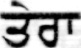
ਤੇਰਾ
